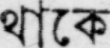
থাকে
